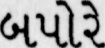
બપોરે
